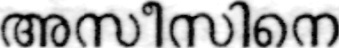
അസീസിനെ
